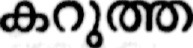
കറുത്ത
